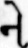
ને
